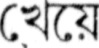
খেয়ে
